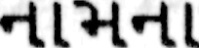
નામના
